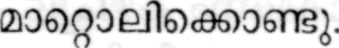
മാറ്റൊലിക്കൊണ്ടു.
